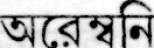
অরেম্বনি
